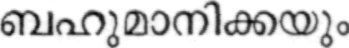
ബഹുമാനിക്കയും
